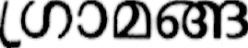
ഗ്രാമങ്ങ
